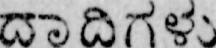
ದಾದಿಗಳು
